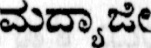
ಮದ್ಯಾಜೀ
